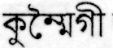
কুম্মৈগী
